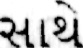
સાથે
